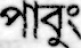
পাবুং
